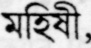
মহিষী,
